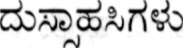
ದುಸ್ಸಾಹಸಿಗಳು
